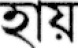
হায়
